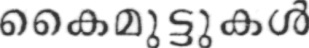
കൈമുട്ടുകള്‍
